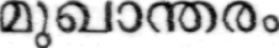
മുഖാന്തരം
